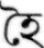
হৈ
